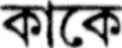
কাকে
